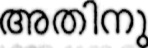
അതിനു
